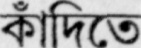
কাঁদিতে
